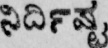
ನಿರ್ದಿಷ್ಟ
